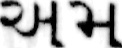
અમ
